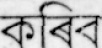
কৰিব
